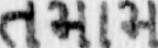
તમામ
